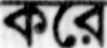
করে
